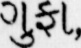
ગુફા,
